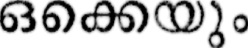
ഒക്കെയും
